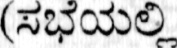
(ಸಭೆಯಲ್ಲಿ
